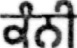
ਕੰਨੀ
